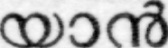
യാന്‍
